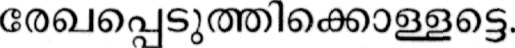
രേഖപ്പെടുത്തിക്കൊള്ളട്ടെ.
